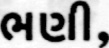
ભણી,
